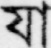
যা
